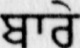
ਬਾਰੇ
